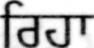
ਰਿਹਾ
